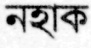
নহাক
